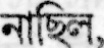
নাছিল,
